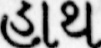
હાથ
